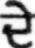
ਦੇ
